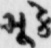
મૂકે
